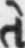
તે
